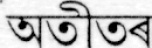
অতীতৰ
